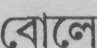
বোলে
